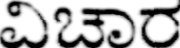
ವಿಚಾರ
